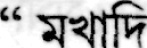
“মখাদি
